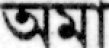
অমা
